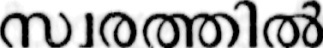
സ്വരത്തില്‍
